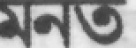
মনত
